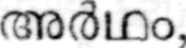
അര്‍ഥം,
